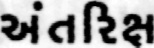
અંતરિક્ષ
